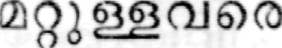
മറ്റുള്ളവരെ
